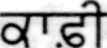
ਕਾਫ਼ੀ
